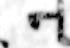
ન
